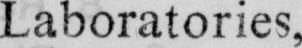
Laboratories,
